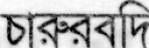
চারুরবদি
